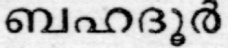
ബഹദൂര്‍
